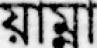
য়াম্না
